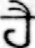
ਹੈ
